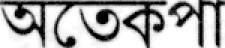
অতেকপা
